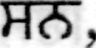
ਸਨ,
